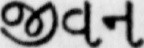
જીવન
